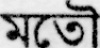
মতৌ
